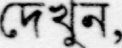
দেখুন,
